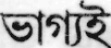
ভাগ্যই
